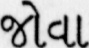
જોવા
